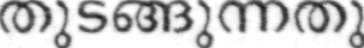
തുടങ്ങുന്നതു
